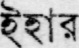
ইহার
